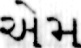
એમ
